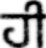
ਹੀ
